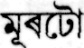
মূৰটো
